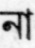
না
